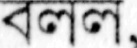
বলল,
